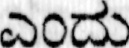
ಎಂದು
